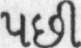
પછી
